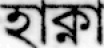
হাক্না
